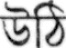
উঠি
